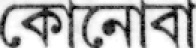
কোনোবা
